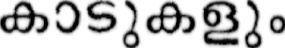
കാടുകളും
